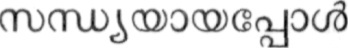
സന്ധ്യയായപ്പോള്‍
